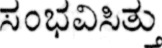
ಸಂಭವಿಸಿತ್ತು
